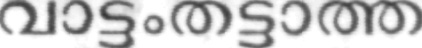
വാട്ടംതട്ടാത്ത
